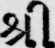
શ્રી
